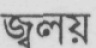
জ্বলয়
